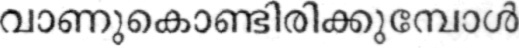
വാണുകൊണ്ടിരിക്കുമ്പോള്‍
